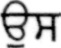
ਉਸ
